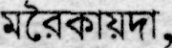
মরৈকায়দা,
